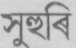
সুহুৰি
